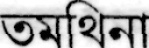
তমথিনা
